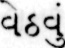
વેઠવું
